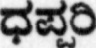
ಧಪ್ಪರಿ
